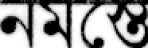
নমস্তে
